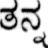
ತನ್ನ
